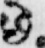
છે.
